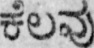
ಕೆಲವು
